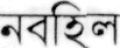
নবহিল
